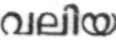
വലിയ
